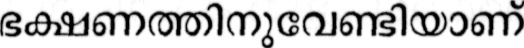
ഭക്ഷണത്തിനുവേണ്ടിയാണ്
